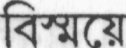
বিস্ময়ে
